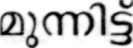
മുന്നിട്ട്
